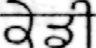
ਕੇਡੀ
